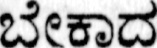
ಬೇಕಾದ
